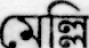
মেল্লি
